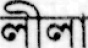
লীলা
